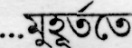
...মুহূর্ততে
